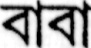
বাবা
